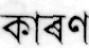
কাৰণ
